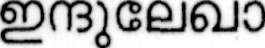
ഇന്ദുലേഖാ
